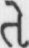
તે
